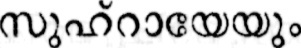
സുഹ്റായേയും
